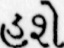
હશે
